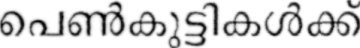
പെണ്‍കുട്ടികള്‍ക്ക്
